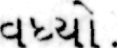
વધ્યો.
